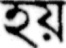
হয়
